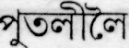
পুতলীলৈ
